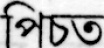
পিচত
